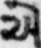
એ
